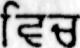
ਵਿਚ
